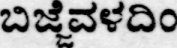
ಬಿಜ್ಜೆವಳದಿಂ
